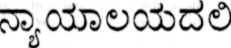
ನ್ಯಾಯಾಲಯದಲಿ
